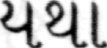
યથા
